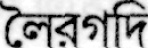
লৈরগদি
